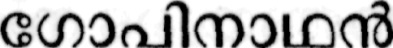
ഗോപിനാഥന്‍
